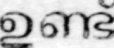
ഉണ്ട്.
